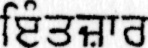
ਇੰਤਜ਼ਾਰ
